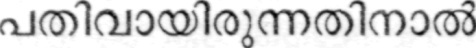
പതിവായിരുന്നതിനാല്‍
